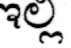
ಇಲ್ಲಿ
